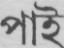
পাই
